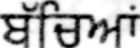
ਬੱਚਿਆਂ
